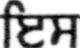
ਇਸ
